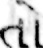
તો
